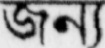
জন্য
